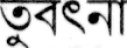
তুবৎনা
